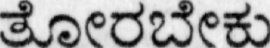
ತೋರಬೇಕು
